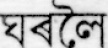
ঘৰলৈ
